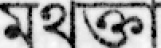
মথক্তা
